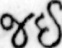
જઈ
